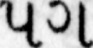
પગ
